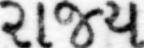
રાજ્ય
